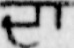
ਦਾ
